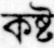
কষ্ট
